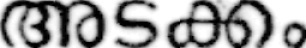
അടക്കം
